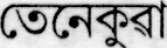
তেনেকুৱা
